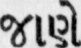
જાણે
